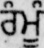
ਰੰਮੂੰ
